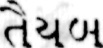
તૈયબ
